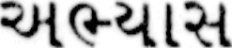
અભ્યાસ
